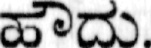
ಹೌದು.
